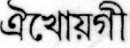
ঐখোয়গী
